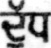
ਦੁੱਧ
